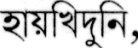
হায়খিদুনি,
